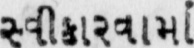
સ્વીકારવામાં
